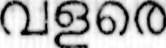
വളരെ
